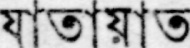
যাতায়াত
